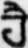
ਹੈ
